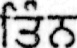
ਤਿੰਨ
